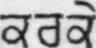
ਕਰਕੇ
